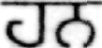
ਹਨ
